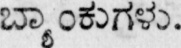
ಬ್ಯಾಂಕುಗಳು.
